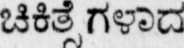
ಚಿಕಿತ್ಸೆಗಳಾದ
